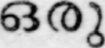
ഒരു
